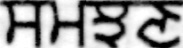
ਸਮਝਣ
